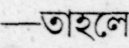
–তাহলে
